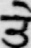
ਤੇ
